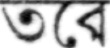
তবে
